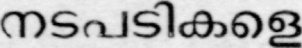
നടപടികളെ
